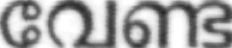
വേണ്ട
